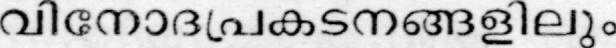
വിനോദപ്രകടനങ്ങളിലും
